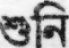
শুনি
